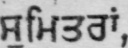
ਸੁਮਿਤਰਾਂ,
